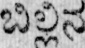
ಬಿಲ್ಲಿನ
